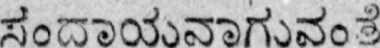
ಸಂದಾಯವಾಗುವಂತೆ
